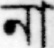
না
